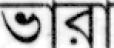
ভারা
